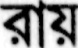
রায়
